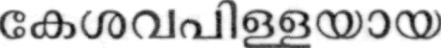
കേശവപിള്ളയായ
